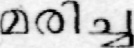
മരിച്ച
